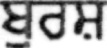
ਬੁਰਸ਼
